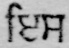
ਇਸ
